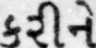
કરીને
